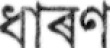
ধাৰণ
